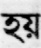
হয়
